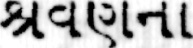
શ્રવણના
